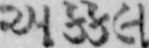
અકક્લ
